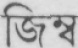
জিম্ব
